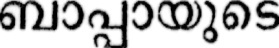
ബാപ്പായുടെ
